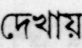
দেখায়
